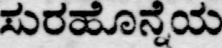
ಸುರಹೊನ್ನೆಯ
